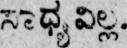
ಸಾಧ್ಯವಿಲ್ಲ.
